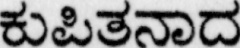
ಕುಪಿತನಾದ
